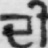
ਦੀ
